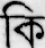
কি
